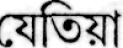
যেতিয়া
